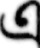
এ
